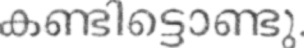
കണ്ടിട്ടൊണ്ടു.
